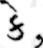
કે,
